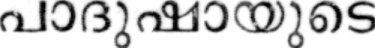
പാദുഷായുടെ
